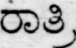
ರಾತ್ರಿ
